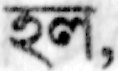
হল,
